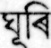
ঘূৰি
